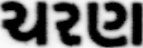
ચરણ
